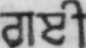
ਗਈ
